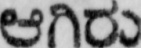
ಆಗಿರು
